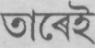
তাৰেই
